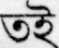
তই
